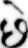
છે
